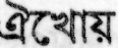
ঐখোয়
